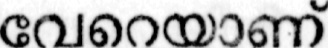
വേറെയാണ്
